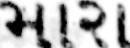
મારા
